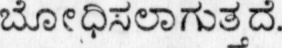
ಬೋಧಿಸಲಾಗುತ್ತದೆ.
